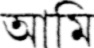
আমি
